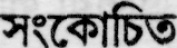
সংকোচিত
